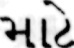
માટે
